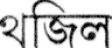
থজিল
